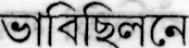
ভাবিছিলনে
